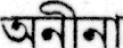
অনীনা
